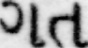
ગત
